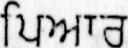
ਪਿਆਰ
